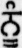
ਨੂੰ
